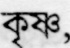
কৃষ্ণ,
